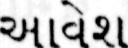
આવેશ
